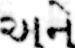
અને
